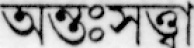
অন্তঃসত্ত্বা
